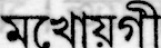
মখোয়গী
